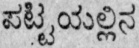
ಪಟ್ಟಿಯಲ್ಲಿನ
